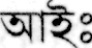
আইঃ
